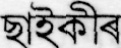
ছাইকীৰ
